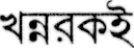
খন্নরকই
